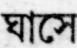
ঘাসে
